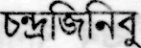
চন্দ্রজিনিবু
